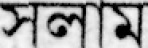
সলাম
